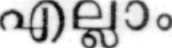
എല്ലാം
